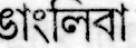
ঙাংলিবা
